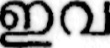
ഇവ
